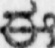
ಈ
